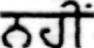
ਨਹੀਂ
